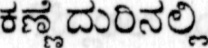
ಕಣ್ಣೆದುರಿನಲ್ಲಿ
